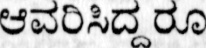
ಆವರಿಸಿದ್ದರೂ
